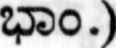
ಭಾ೦.)
